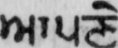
ਆਪਣੇ
